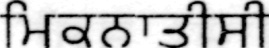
ਮਿਕਨਾਤੀਸੀ
